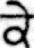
ਕੇ
